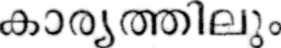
കാര്യത്തിലും
